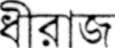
ধীরাজ
